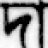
দা
